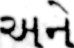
અને
